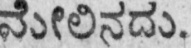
ಮೇಲಿನದು.
